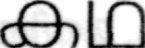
കഥ
